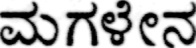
ಮಗಳೇನ
